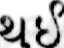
થઈ
